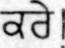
ਕਰੇ!
